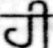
ਹੀ
